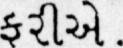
ફરીએ.
